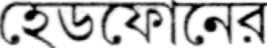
হেডফোনের
